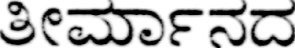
ತೀರ್ಮಾನದ
